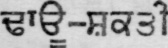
ਢਾਊ-ਸ਼ਕਤੀ
